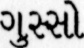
ગુસ્સો
